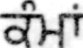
ਕੰਮਾਂ
